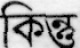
কিন্তু
